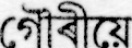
গৌৰীয়ে
